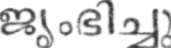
ജൃംഭിച്ചു
